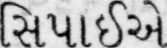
સિપાઈએ
